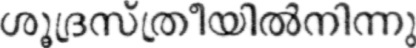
ശൂദ്രസ്ത്രീയില്‍നിന്നു
